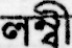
লম্বী
